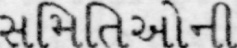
સમિતિઓની
